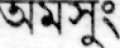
অমসুং
